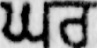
ਘਰ
